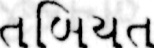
તબિયત
